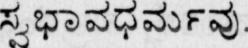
ಸ್ವಭಾವಧರ್ಮವು.
